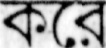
করে
